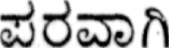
ಪರವಾಗಿ
